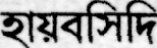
হায়বসিদি
